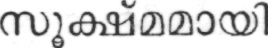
സൂക്ഷ്മമായി
